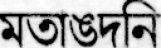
মতাঙদনি
